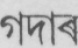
গদাৰ
